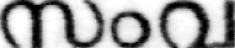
സംവ
